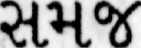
સમજ
